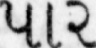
પાર
